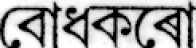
বোধকৰো
